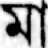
মা
